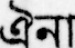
ঐনা
